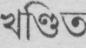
খণ্ডিত
